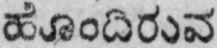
ಹೊಂದಿರುವ
